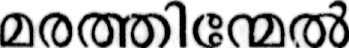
മരത്തിന്മേല്‍
